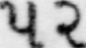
પર
